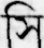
সি
